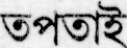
তপতাই
